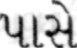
પાસે
